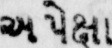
અપેક્ષા
